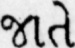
જાતે
